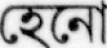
হেনো
